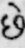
છે
